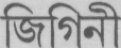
জিগিনী
